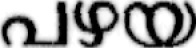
പഴയ
